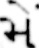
મેં
